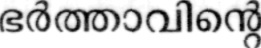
ഭര്‍ത്താവിന്റെ
